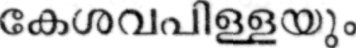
കേശവപിള്ളയും
